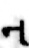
ન
